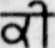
ਕੀ
